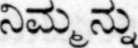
ನಿಮ್ಮನ್ನು
